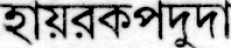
হায়রকপদুদা
